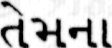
તેમના
